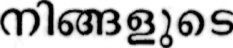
നിങ്ങളുടെ
